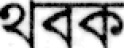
থবক
